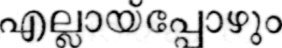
എല്ലായ്പ്പോഴും
